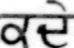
ਕਦੇ
